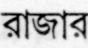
রাজার
